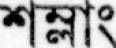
শম্লাং
